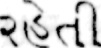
રહેતી
